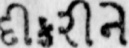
દીકરીને
